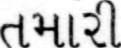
તમારી
